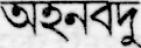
অহনবদু
